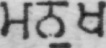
ਮਨੁਖ
